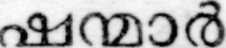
ഷന്മാര്‍
